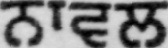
ਨਾਵਲ
